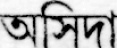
অসিদা
